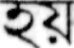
হয়
